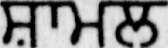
ਸ਼ਾਮਲ
